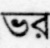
ভর
